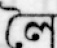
লৈ
